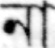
না
